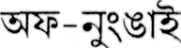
অফ-নুংঙাই
